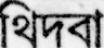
থিদবা
